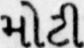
મોટી
